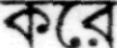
করে
